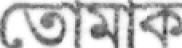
তোমাক
